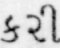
કરી
